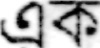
এক
